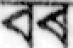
বৰ
